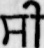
ਸੀ
